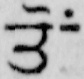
ਤੋਂ
